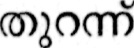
തുറന്ന്
